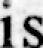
is
